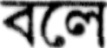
বলে
